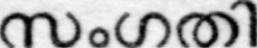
സംഗതി
